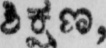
ಶಿಕ್ಷಣ,
